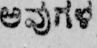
ಅವುಗಳ
